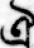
ঐ
